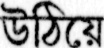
উঠিয়ে
